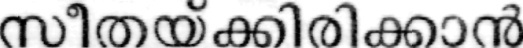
സീതയ്ക്കിരിക്കാന്‍
